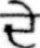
ਦੇ
